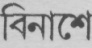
বিনাশে
